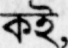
কই,
